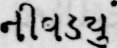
નીવડ્યું
